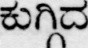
ಕುಗ್ಗಿದ
